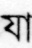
যা
